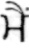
ਮੈਂ
